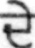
ਦੇ
